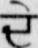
ਦੇ
